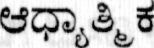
ಆಧ್ಯಾತ್ಮಿಕ
